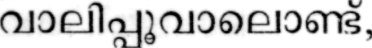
വാലിപ്പൂവാലൊണ്ട്,
